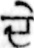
ਦੇ
